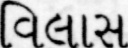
વિલાસ
